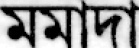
মমাদা
